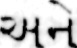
અને
